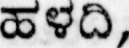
ಹಳದಿ,
